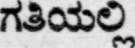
ಗತಿಯಲ್ಲಿ
